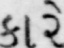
કારે
